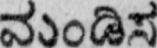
ಮಂಡಿಸ
